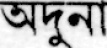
অদুনা
